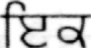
ਇਕ
